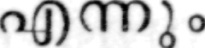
എന്നും
